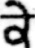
ਕੇ
